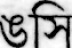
ঙসি
